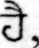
ਹੈ,
